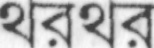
থরথর
